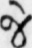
જે
